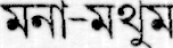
মনা-মথুম
